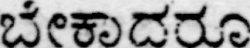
ಬೇಕಾದರೂ
